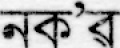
নক'ৱ
